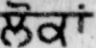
ਲੋਕਾਂ
